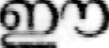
ഈ
